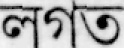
লগত
